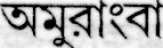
অমুরাংবা
